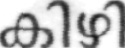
കിഴി
